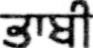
ਭਾਬੀ
